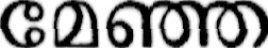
മേഞ്ഞ
